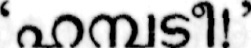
'ഹമ്പടീ!'
